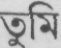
তুমি
